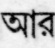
আর
